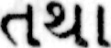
તથા
